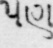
પણ
